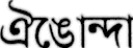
ঐঙোন্দা
